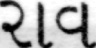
રાવ
